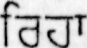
ਰਿਹਾ
